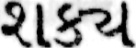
શક્ય
